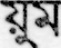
য়ুম
